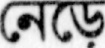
নেড়ে
